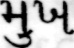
મુખ
